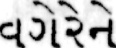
વગેરેને
